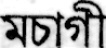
মচাগী
